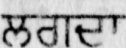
ਲਗਦਾ
